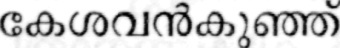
കേശവന്‍കുഞ്ഞ്
